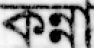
কন্না
